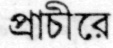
প্রাচীরে
